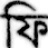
ফি
